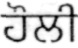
ਹੌਲੀ
